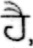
ਹੈ,
